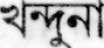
খন্দুনা
